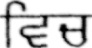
ਵਿਚ
